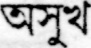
অসুখ
